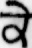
ਕੇ
